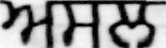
ਅਸਲ
